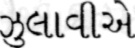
ઝુલાવીએ
